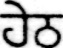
ਹੇਠ
